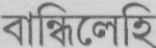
বান্ধিলেহি
